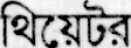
থিয়েটর
